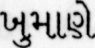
ખુમાણે
